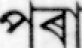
পৰা
